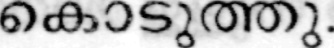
കൊടുത്തു.
